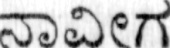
ನಾವೀಗ
